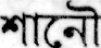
শানৌ
